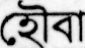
হৌবা
